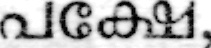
പക്ഷേ,
